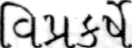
વિપ્રકર્ષે
